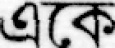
একে
